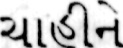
ચાહીને
